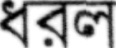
ধরল
